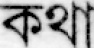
কথা
